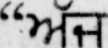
''ਅੱਜ
